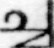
ച്ച
